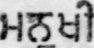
ਮਨੁਖੀ
